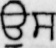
ਉਸ
